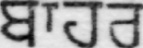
ਬਾਹਰ
